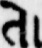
તો
